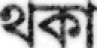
থকা
